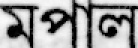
মপাল
